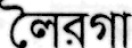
লৈরগা
